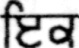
ਇਕ
